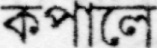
কপালে
